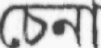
চেনা
